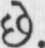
છે.
